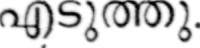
എടുത്തു.
